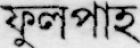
ফুলপাহ
